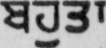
ਬਹੁਤਾ
